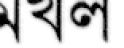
মখল
